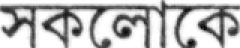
সকলোকে
